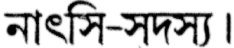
নাৎসি-সদস্য।
